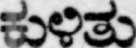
ಕುಳಿತು
